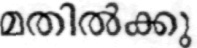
മതില്‍ക്കു
